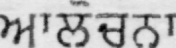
ਆਲੋਚਨਾ
